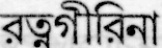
রত্নগীরিনা
